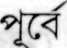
পূৰ্বে
